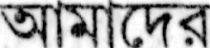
আমাদের
